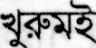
খুরুমই
